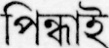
পিন্ধাই
